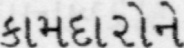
કામદારોને
